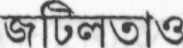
জটিলতাও
